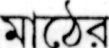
মাঠের
